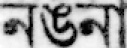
নঙনা
